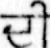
ਦੀ
